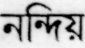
নন্দিয়
